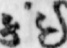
કંઈ
